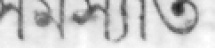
সমস্যাত
